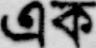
এক
